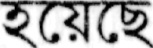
হয়েছে
